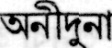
অনীদুনা
